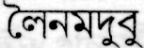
লৈনমদুবু
